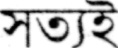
সত্যই
